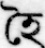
হৈ
